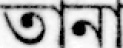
তানা
